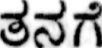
ತನಗೆ
